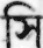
সি
